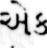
એક
